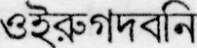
ওইরুগদবনি
